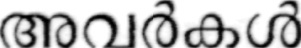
അവര്‍കള്‍
